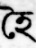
হৈ
